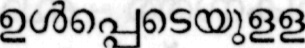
ഉള്‍പ്പെടെയുള്ള
